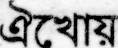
ঐখোয়
